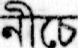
নীচে
